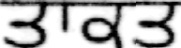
ਤਾਕਤ
